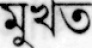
মুখত
